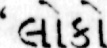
'લોકો
